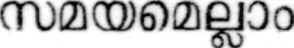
സമയമെല്ലാം
